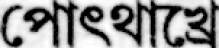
পোৎথাখ্রে
